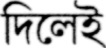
দিলেই
